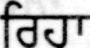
ਰਿਹਾ
